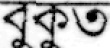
বুকুত
